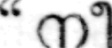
“നീ
